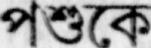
পশুকে
